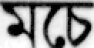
মচে
